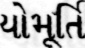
યોમૂર્તિ
